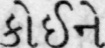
કોઈને
